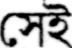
সেই
